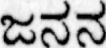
ಜನನ
